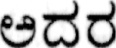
ಅದರ
